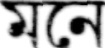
মনে
